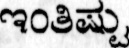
ಇಂತಿಷ್ಟು
